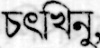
চৎখিনু,
